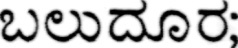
ಬಲುದೂರ;
